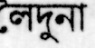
লৈদুনা
